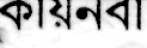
কায়নবা
